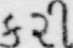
કરી
